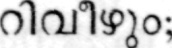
റിവീഴും;
